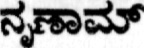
ನೃಣಾಮ್
